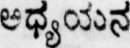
ಅಧ್ಯಯನ
